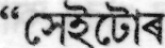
"সেইটোৰ
